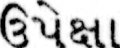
ઉપેક્ષા
